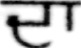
ਦਾ
